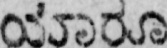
ಯಾರೂ
